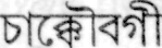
চাক্কৌবগী
